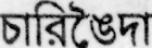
চারিঙৈদা
